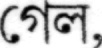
গেল,
